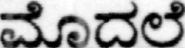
ಮೊದಲೆ
